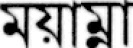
ময়াম্না
